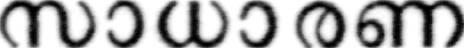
സാധാരണ
